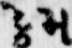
કેમ
